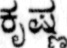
ಕೃಷ್ಣ
